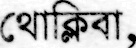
থোক্লিবা,
